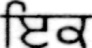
ਇਕ
